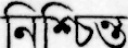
নিশ্চিন্ত
